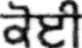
ਕੋਈ
